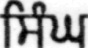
ਸਿੰਘ
